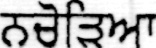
ਨਚੋੜਿਆ
